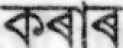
কৰাৰ
